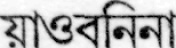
য়াওবনিনা
